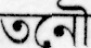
তনৌ
